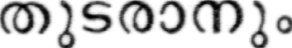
തുടരാനും
